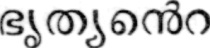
ഭൃത്യന്റെ
